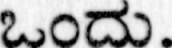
ಒಂದು.
